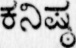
ಕನಿಷ್ಠ
